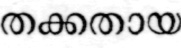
തക്കതായ
